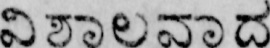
ವಿಶಾಲವಾದ
